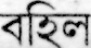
বহিল
